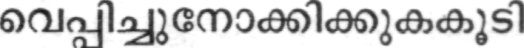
വെപ്പിച്ചുനോക്കിക്കുകകൂടി
